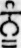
ਨੂੰ
